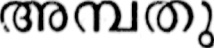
അമ്പതു
